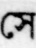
সে
